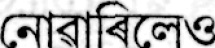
নোৱাৰিলেও
